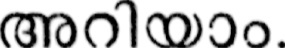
അറിയാം.
